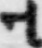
ન
